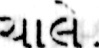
ચાલે.
